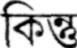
কিন্তু
